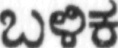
ಬಳಿಕ
